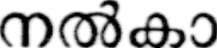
നല്‍കാ
